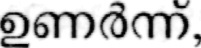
ഉണര്‍ന്ന്,
